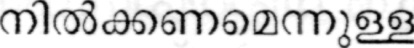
നില്‍ക്കണമെന്നുള്ള
